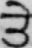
ਤੇ
